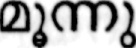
മൂന്നു
